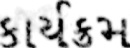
કાર્યક્રમ
